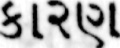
કારણ
